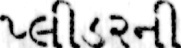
પ્લીડરની
